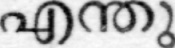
എന്തു
